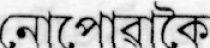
নোপোৱাকৈ
